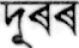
দূৰৰ
